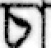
চা
